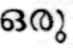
ഒരു
